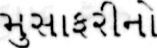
મુસાફરીનો
